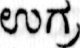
ಉಗ್ರ
